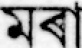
মৰা
